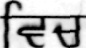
ਵਿਚ
